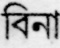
বিনা
